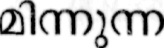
മിന്നുന്ന
